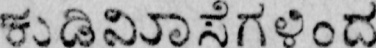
ಕುಡಿಮೀಸೆಗಳಿಂದ
